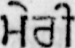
ਮੇਰੀ
